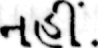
નહીં.
